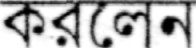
করলেন
